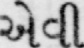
એવી
